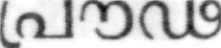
പ്രൌഢ
